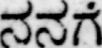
ನನಗೆ
